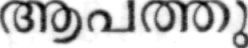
ആപത്തു
